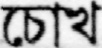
চোখ
